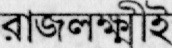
রাজলক্ষ্মীই
